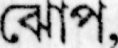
ঝোপ,
